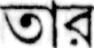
তার
